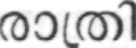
രാത്രി
